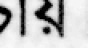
চায়
